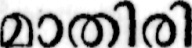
മാതിരി
